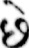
છે
